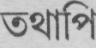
তথাপি
